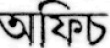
অফিচ
